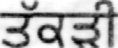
ਤੱਕੜੀ
